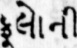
ફૂલોની
